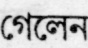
গেলেন
